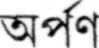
অর্পণ
